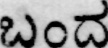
ಬಂದ
